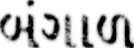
બંગાળ
